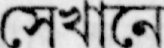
সেখানে
